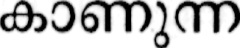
കാണുന്ന
